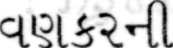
વણકરની
